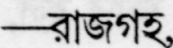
–রাজগহ,
